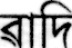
ৱাদি
